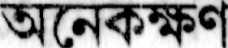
অনেকক্ষণ
